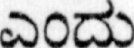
ಎಂದು
